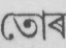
তোৰ
